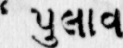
'પુલાવ
